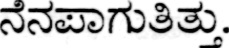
ನೆನಪಾಗುತಿತ್ತು.
